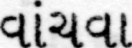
વાંચવા
